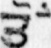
ਤੋਂ
